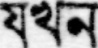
যখন
